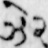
ઝેર
